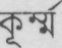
কূৰ্ম্ম
